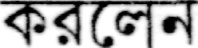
করলেন
